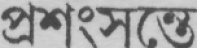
প্ৰশংসন্তে
